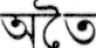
অতৈ
